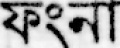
ফংনা
